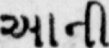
આની
